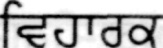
ਵਿਹਾਰਕ
